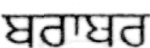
ਬਰਾਬਰ
